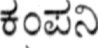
ಕಂಪನಿ
